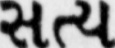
સત્ય
